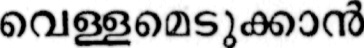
വെള്ളമെടുക്കാന്‍
